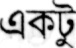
একটু
